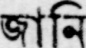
জানি
